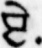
ਏ.
